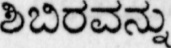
ಶಿಬಿರವನ್ನು
